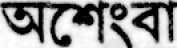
অশেংবা
